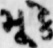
મૂકે
